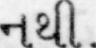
નથી.
